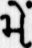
મેં
